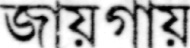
জায়গায়
